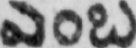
ಎಂಬ
